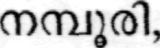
നമ്പൂരി,
